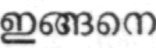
ഇങ്ങനെ
